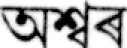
অশ্বৰ
